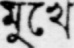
মুখে
